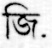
জি.
